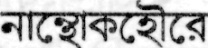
নান্থোকহৌরে
